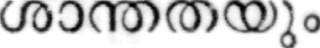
ശാന്തതയും
